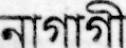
নাগাগী
